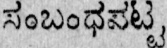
ಸಂಬಂಧಪಟ್ಟ
